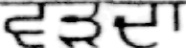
ਵੜਦਾ
